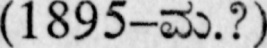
(1895-ಮ.?)
